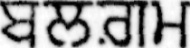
ਬਲਗ਼ਮ
